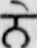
ਨੇ
